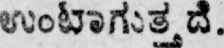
ಉಂಟಾಗುತ್ತದೆ.
